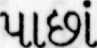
પાછાં
